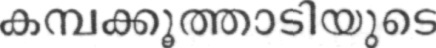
കമ്പക്കൂത്താടിയുടെ
